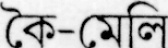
কৈ-মেলি
